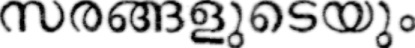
സരങ്ങളുടെയും
